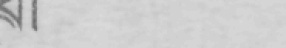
ৱা
